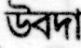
উবদা
